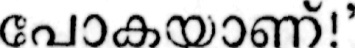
പോകയാണ്!’
